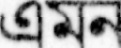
এমন
